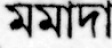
মমাদা
